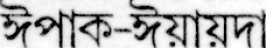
ঈপাক-ঈয়ায়দা
